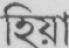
হিয়া
